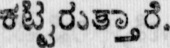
ಕಟ್ಟಿರುತ್ತಾರೆ.
